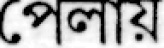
পেলায়
